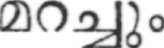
മറച്ചും
